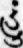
હું
